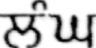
ਲੰਘ
